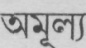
অমূল্য
